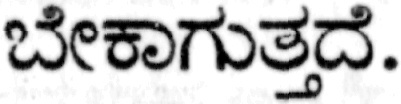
ಬೇಕಾಗುತ್ತದೆ.
